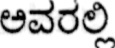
ಅವರಲ್ಲಿ
